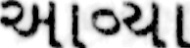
આવ્યા
